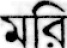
মরি
